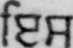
ਇਸ
